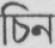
চিন
